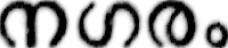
നഗരം
